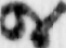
જ
